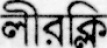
লীরক্লি
